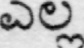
ಎಲ್ಲ
